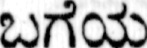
ಬಗೆಯ
